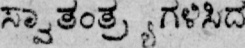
ಸ್ವಾತಂತ್ರ್ಯಗಳಿಸಿದ
